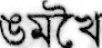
ঙমখৈ
